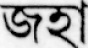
জহা
